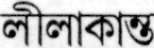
লীলাকান্ত
